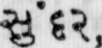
સુંદર,
